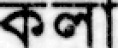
কলা
